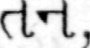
તન,
